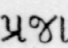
પ્રજા
